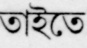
তাইতে
